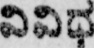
ವಿವಿಧ
